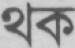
থক
